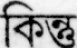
কিন্তু
